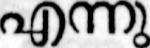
എന്നു
